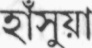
হাঁসুয়া
